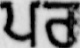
ਪਰ
